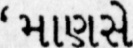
'માણસે
